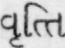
વૃત્તિ
